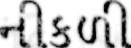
નીકળી
